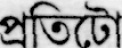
প্রতিটো
